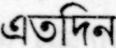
এতদিন
